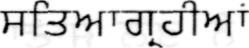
ਸਤਿਆਗ੍ਰਹੀਆਂ
